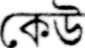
কেউ
